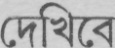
দেখিবে
